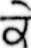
ਕੇ
